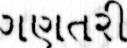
ગણતરી
